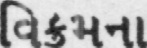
વિક્રમના
